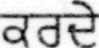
ਕਰਦੇ
